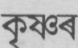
কৃষ্ণৰ
